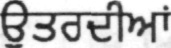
ਉਤਰਦੀਆਂ
